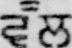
ਵਲ
